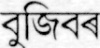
বুজিবৰ
